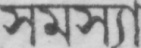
সমস্যা
